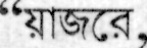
“য়াজরে,
